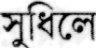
সুধিলে
